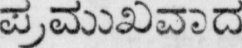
ಪ್ರಮುಖವಾದ
